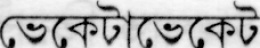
ভেকেটাভেকেট
